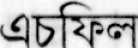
এচফিল
